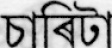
চাৰিটা
